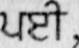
ਪਈ,
